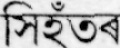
সিহঁতৰ
